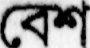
বেশ
